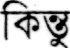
কিন্তু
